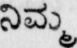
ನಿಮ್ಮ
